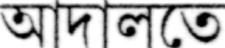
আদালতে
